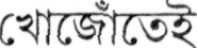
খোজোঁতেই
